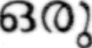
ഒരു
